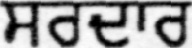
ਸਰਦਾਰ
